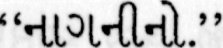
"નાગનીનો."
